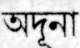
অদূনা
